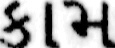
કામ
